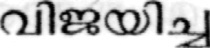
വിജയിച്ച
